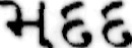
મદદ
